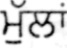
ਮੁੱਲਾਂ
